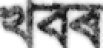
খবৰ
